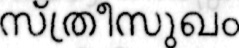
സ്ത്രീസുഖം
